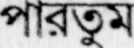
পারতুম
